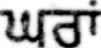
ਘਰਾਂ
